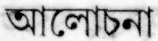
আলোচনা
